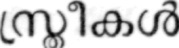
സ്ത്രീകള്‍
